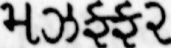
મઝફ્ફર
